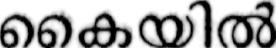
കൈയില്‍
